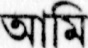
আমি
